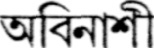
অবিনাশী
